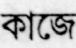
কাজে
